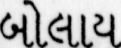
બોલાય
